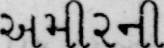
અમીરની
